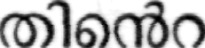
തിന്റെ
